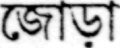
জোড়া
